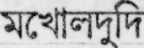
মখোলদুদি
